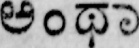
ಅಂಥಾ
